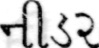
નીડર
